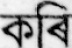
কৰি
